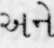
અને
